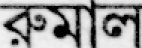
রুমাল
